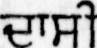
ਦਾਸੀ
